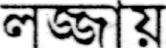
লজ্জায়
